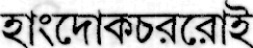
হাংদোকচররোই
